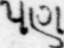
પણ
